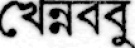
খেন্নববু
